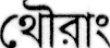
থৌরাং
